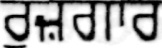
ਰੁਜ਼ਗਾਰ
